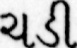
ચડી
